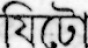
যিটো
